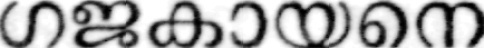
ഗജകായനെ
